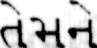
તેમને
